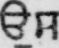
ਉਸ
